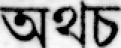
অথচ
